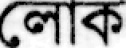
লোক
